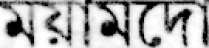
ময়ামদো
